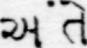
અંતે
